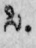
ಸಿ.
